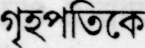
গৃহপতিকে
